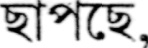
ছাপছে,
